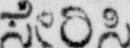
ಸೇರಿಸಿ
